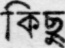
কিছু
